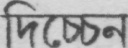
দিচ্চেন
